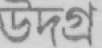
উদগ্ৰ
